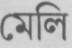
মেলি
